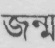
জন্ম
